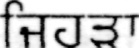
ਜਿਹੜਾ
